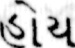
હોય
